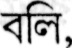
বলি,
